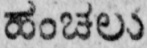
ಹಂಚಲು
